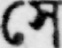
সে
